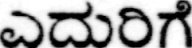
ಎದುರಿಗೆ
